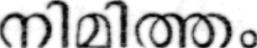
നിമിത്തം
